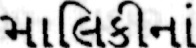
માલિકીનાં
